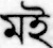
মই
